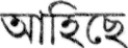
আহিছে
